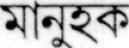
মানুহক
